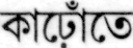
কাঢ়োঁতে
